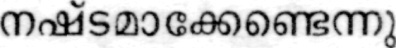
നഷ്ടമാക്കേണ്ടെന്നു
